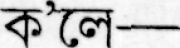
ক'লে-
